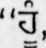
''ਹੂੰ,
